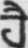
ਹੈ
